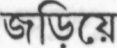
জড়িয়ে
